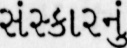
સંસ્કારનું
